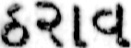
ઠરાવ
